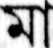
মা
